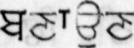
ਬਣਾਉਣ
